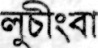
লুচীংবা
